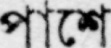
পাশে
